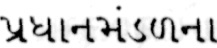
પ્રધાનમંડળના
